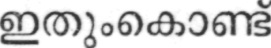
ഇതുംകൊണ്ട്
